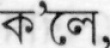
ক'লে,
